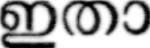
ഇതാ
